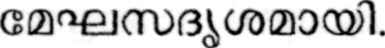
മേഘസദൃശമായി.
